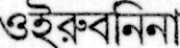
ওইরুবনিনা
